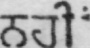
ਨਹੀਂ
